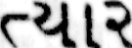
ત્યાર
